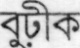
বুঢ়ীক
